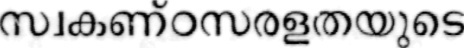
സ്വകണ്ഠസരളതയുടെ
